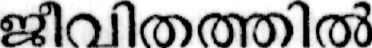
ജീവിതത്തില്‍
